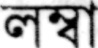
লম্বা
